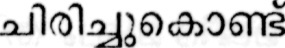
ചിരിച്ചുകൊണ്ട്
